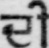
ਦੀ
